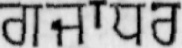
ਗਜਾਧਰ
